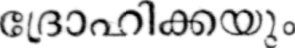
ദ്രോഹിക്കയും
